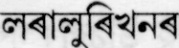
লৰালুৰিখনৰ
